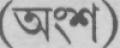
(অংশ)
